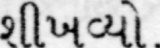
શીખવ્યો.
